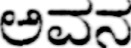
ಅವನ
